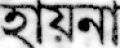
হায়না
